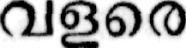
വളരെ
